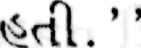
હતી."
